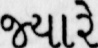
જ્યારે
